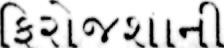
ફિરોજશાની
